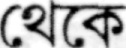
থেকে
